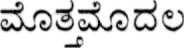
ಮೊತ್ತಮೊದಲ
